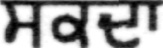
ਸਕਦਾ
